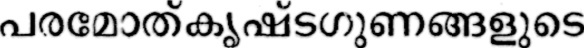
പരമോത്കൃഷ്ടഗുണങ്ങളുടെ
